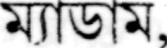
ম্যাডাম,
